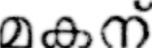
മകന്
